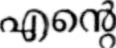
എന്റെ
